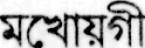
মখোয়গী
